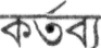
কর্তব্য
